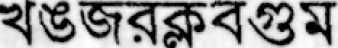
খঙজরক্লবগুম
